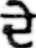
ਦੇ
